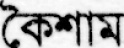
কৈশাম
